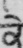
ਕੇ
